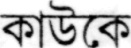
কাউকে
